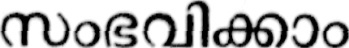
സംഭവിക്കാം
